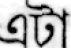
এটা
